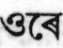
ওৰে
